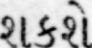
શકશે
